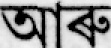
আৰু
